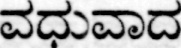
ವಧುವಾದ
